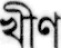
খীণ
